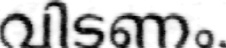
വിടണം.
